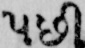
પછી
